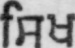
ਸਿਖ
